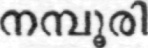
നമ്പൂരി
